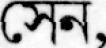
সেন,
